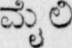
ಮೈಲಿ
